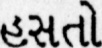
હસતો
